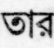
তার
